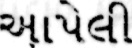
આપેલી
